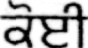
ਕੋਈ
